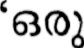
'ഒരു
